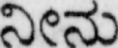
ನೀನು
